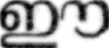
ഈ
